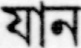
যান
